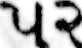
પર
